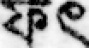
ফৎ
